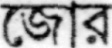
জোর
